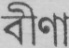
বীণা
